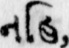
નહિ,
